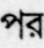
পর
